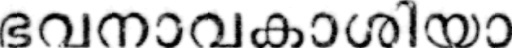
ഭവനാവകാശിയാ
